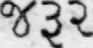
જરૂર
